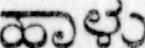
ಹಾಳು
